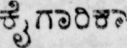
ಕೈಗಾರಿಕಾ
